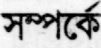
সম্পর্কে
